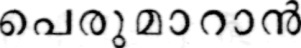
പെരുമാറാന്‍
